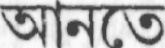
আনতে
